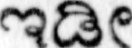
ಇಡೀ
